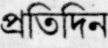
প্রতিদিন
